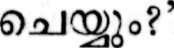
ചെയ്യും?'
